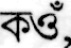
কওঁ,
